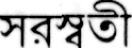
সরস্বতী
